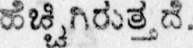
ಹೆಚ್ಚಿಗಿರುತ್ತದೆ.
